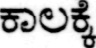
ಕಾಲಕ್ಕೆ
